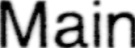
Main
